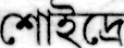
শোইদ্রে
